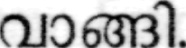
വാങ്ങി.
